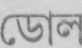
ডোল
